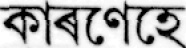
কাৰণেহে
